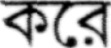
করে
